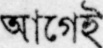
আগেই
